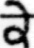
ਕੇ
